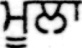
ਮੂਲਾ
